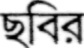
ছবির
